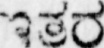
ಇತರ
